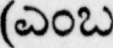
(ಎಂಬ
